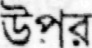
উপর
